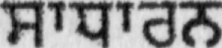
ਸਾਧਾਰਨ
